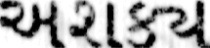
અશક્ય
